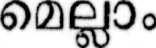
മെല്ലാം
